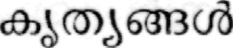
കൃത്യങ്ങള്‍
